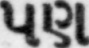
પણ
